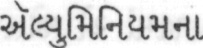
ઍલ્યુમિનિયમના
